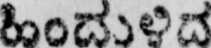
ಹಿಂದುಳಿದ
